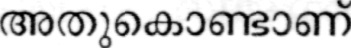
അതുകൊണ്ടാണ്
